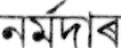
নর্মদাৰ
